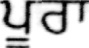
ਪੂਰਾ
